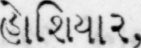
હોશિયાર,
